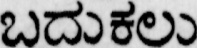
ಬದುಕಲು
